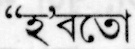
"হ'বতো
